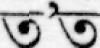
ত'ত
